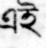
এই
